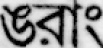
ঙরাং
